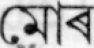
মোৰ
